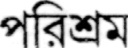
পরিশ্রম
